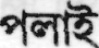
পলাই
